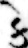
કે
